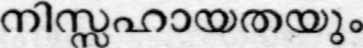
നിസ്സഹായതയും
